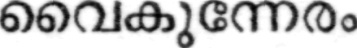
വൈകുന്നേരം
